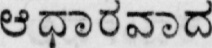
ಆಧಾರವಾದ
